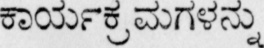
ಕಾರ್ಯಕ್ರಮಗಳನ್ನು
